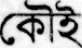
কৌই
